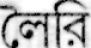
লৈরি
